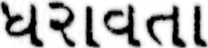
ધરાવતા
